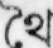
থৈ
